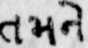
તમને
